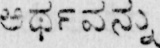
ಅರ್ಥವನ್ನು
